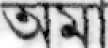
অমা
